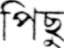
পিছু
